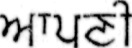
ਆਪਣੀ
